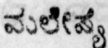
ಮಲೇಷ್ಯ
